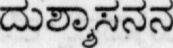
ದುಶ್ಯಾಸನನ
